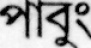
পাবুং
